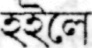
হইলে
